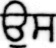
ਉਸ
